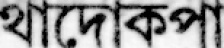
থাদোকপা
